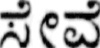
ಸೇವೆ
